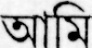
আমি
